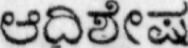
ಆದಿಶೇಷ
